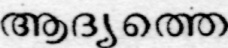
ആദ്യത്തെ
